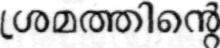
ശ്രമത്തിന്റെ
